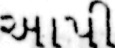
આપી
